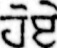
ਹੋਏ
